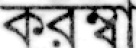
করম্বা
